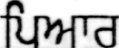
ਪਿਆਰ
